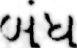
બંધ
